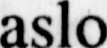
also
